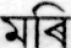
মৰি
